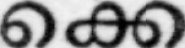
ക്കെ
